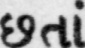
છતાં
